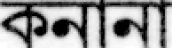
কনানা
